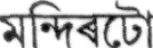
মন্দিৰটো
